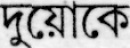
দুয়োকে
